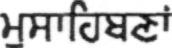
ਮੁਸਾਹਿਬਣਾਂ
